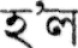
হ'ল
